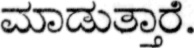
ಮಾಡುತ್ತಾರೆ.
